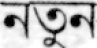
নতুন
